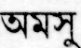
অমসু
